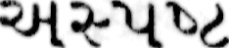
અસ્પષ્ટ
